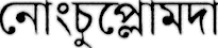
নোংচুপ্লোমদা
